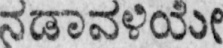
ನಡಾವಳಿಯೇ
